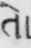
તો
